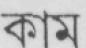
কাম
